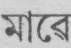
মাৱে
